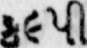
કલ્પી
